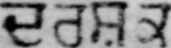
ਦਰਸ਼ਕ
